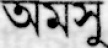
অমসু
